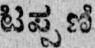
ಟಿಪ್ಪಣಿ
